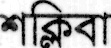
শক্লিবা
